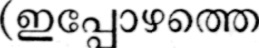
(ഇപ്പോഴത്തെ
